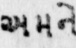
અમને
